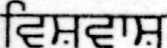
ਵਿਸ਼ਵਾਸ਼
